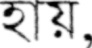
হায়,
